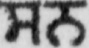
ਸਨ
